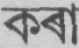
কৰা
